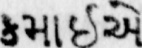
કમાઈએ
